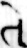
તે
